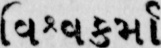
વિશ્વકર્મા
